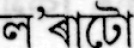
ল'ৰাটো
